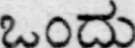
ಒ೦ದು
